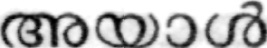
അയാള്‍
